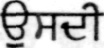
ਉਸਦੀ
